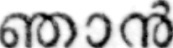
ഞാന്‍
